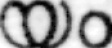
യം
